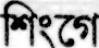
শিংগে
